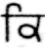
ਕਿ
